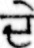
ਦੇ
